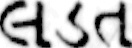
લડત
